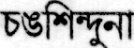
চঙশিন্দুনা
